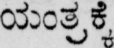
ಯಂತ್ರಕ್ಕೆ
